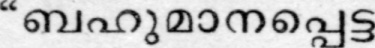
"ബഹുമാനപ്പെട്ട
